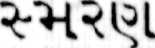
સ્મરણ
